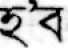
হ'ব
